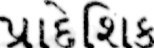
પ્રાદેશિક
